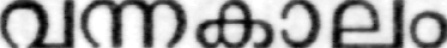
വന്നകാലം
